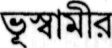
ভূস্বামীর
